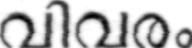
വിവരം
